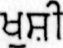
ਖੁਸ਼ੀ
